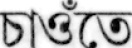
চাওঁতে
